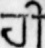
ਹੀ
